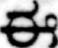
ಈ
